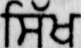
ਸਿੱਖ
